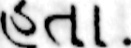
હતા.
